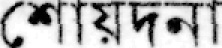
শোয়দনা
